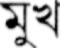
মুখ
